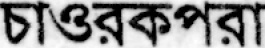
চাওরকপরা
